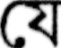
যে
